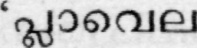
‘പ്ലാവെല
